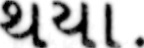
થયા.
